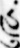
હું
